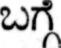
ಬಗ್ಗೆ
